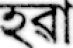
হৱা
